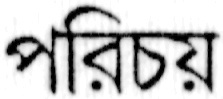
পরিচয়
